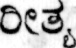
ರೀತ್ಯ
